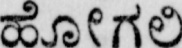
ಹೋಗಲಿ
